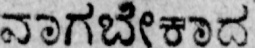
ವಾಗಬೇಕಾದ
